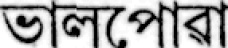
ভালপোৱা
